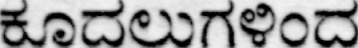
ಕೂದಲುಗಳಿಂದ
